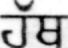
ਹੱਥ
